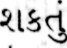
શકતું
